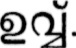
ഉവ്വ്.
